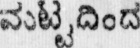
ಮಟ್ಟದಿಂದ
